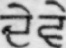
ਦੇਵੇ
